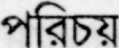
পরিচয়
